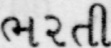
ભરતી
